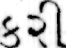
કરી
